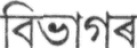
বিভাগৰ
